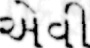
એવી
